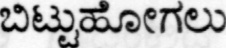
ಬಿಟ್ಟುಹೋಗಲು
